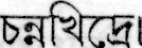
চন্নখিদ্রে।
